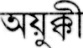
অয়ুক্কী
